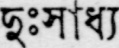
দুঃসাধ্য
